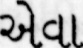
એવા
